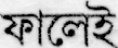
ফালেই
